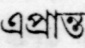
এপ্রান্ত
